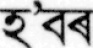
হ'বৰ
